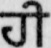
ਹੀ
